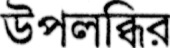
উপলব্ধির
